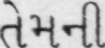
તેમની
